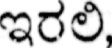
ಇರಲಿ,
